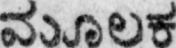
ಮೂಲಕ
